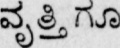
ವೃತ್ತಿಗೂ
